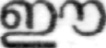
ഈ
